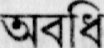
অবধি
